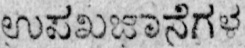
ಉಪಖಜಾನೆಗಳ
